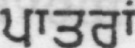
ਪਾਤਰਾਂ
